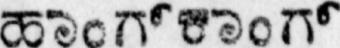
ಹಾಂಗ್‌ಕಾಂಗ್
